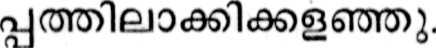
പ്പത്തിലാക്കിക്കളഞ്ഞു.
